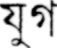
যুগ
